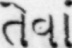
તેવાં
